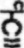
ਨੂੰ
